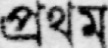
প্রথম
